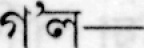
গ'ল-
